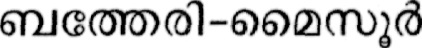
ബത്തേരി-മൈസൂര്‍
